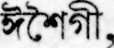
ঈশৈগী,
